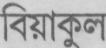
বিয়াকুল
